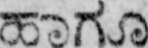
ಹಾಗೂ
